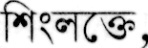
শিংলক্তে,
